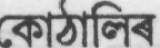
কোঠালিৰ
